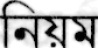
নিয়ম
